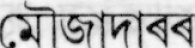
মৌজাদাৰৰ
